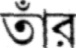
তাঁর
